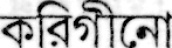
করিগীনো
